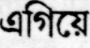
এগিয়ে
